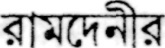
রামদেনীর
